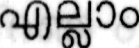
എല്ലാം
